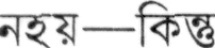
নহয়-কিন্তু
